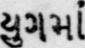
યુગમાં
